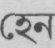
হেন
